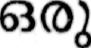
ഒരു
